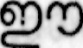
ഈ
